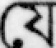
যে
